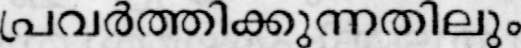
പ്രവര്‍ത്തിക്കുന്നതിലും
